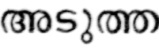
അടുത്ത
